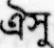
ঐসু
